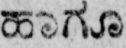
ಹಾಗೂ
